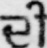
ਦੀ
